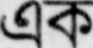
এক
